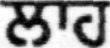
ਲਾਹ
